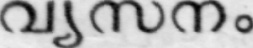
വ്യസനം
